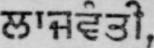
ਲਾਜਵੰਤੀ,
